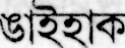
ঙাইহাক
